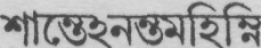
শান্তেহনন্তমহিম্নি
